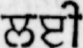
ਲਈ
